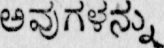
ಅವುಗಳನ್ನು
